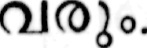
വരും.
